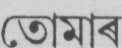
তোমাৰ
